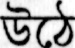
উঠে
